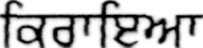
ਕਿਰਾਇਆ
